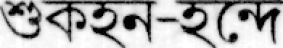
শুকহন-হন্দে
